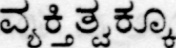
ವ್ಯಕ್ತಿತ್ವಕ್ಕೂ
